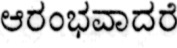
ಆರಂಭವಾದರೆ
